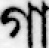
গা
